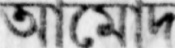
আমোদ
